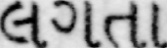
લગતા
